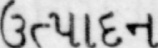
ઉત્પાદન
